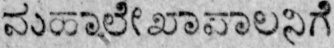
ಮಹಾಲೇಖಾಪಾಲನಿಗೆ
